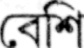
বেশি
